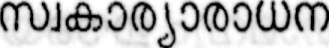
സ്വകാര്യാരാധന
